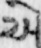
એ
